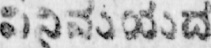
ವಿನಿಮಯದ
